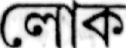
লোক
